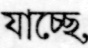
যাচ্ছে,
